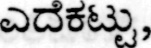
ಎದೆಕಟ್ಟು,
